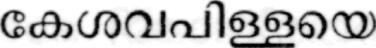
കേശവപിള്ളയെ
